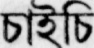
চাইচি
